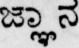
ಜ್ಞಾನ
